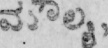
ಮೌಲ್ಯ,
